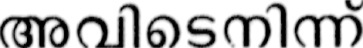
അവിടെനിന്ന്
